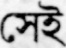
সেই
